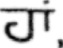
ਹਾਂ,
